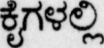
ಕೈಗಳಲ್ಲಿ
